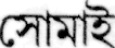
সোমাই
